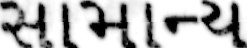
સામાન્ય
